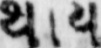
થાય
